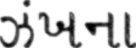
ઝંખના
